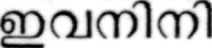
ഇവനിനി
